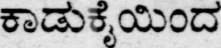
ಕಾಡುಕೈಯಿಂದ
